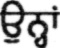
ਉਨ੍ਹਾਂ
